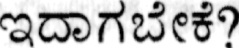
ಇದಾಗಬೇಕೆ?
